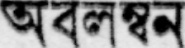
অবলম্বন
